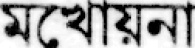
মখোয়না
